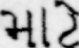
માટે
